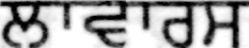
ਲਾਵਾਰਸ
